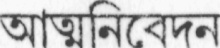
আত্মনিবেদন
